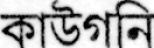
কাউগনি
